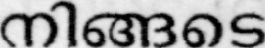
നിങ്ങടെ
